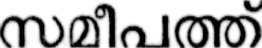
സമീപത്ത്
